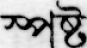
স্পষ্ট
